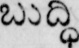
ಬುದ್ಧಿ
